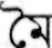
মৈ
